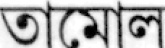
তামোল
